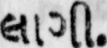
લાગી.
